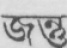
জন্তু
